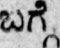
ಬಗ್ಗೆ
